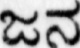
ಜನ
